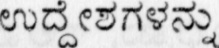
ಉದ್ದೇಶಗಳನ್ನು
